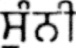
ਸੁੰਨੀ
